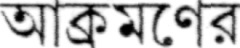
আক্রমণের
